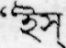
"ইস্
